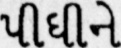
પીધીને
